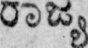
ರಾಜ್ಯ
